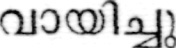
വായിച്ചു
